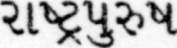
રાષ્ટ્રપુરુષ
